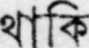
থাকি
